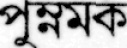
পুম্নমক
